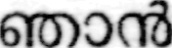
ഞാന്‍
